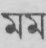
মম
